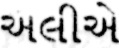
અલીએ
